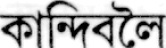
কান্দিবলৈ
